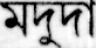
মদুদা
